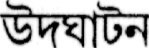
উদঘাটন
